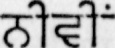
ਨੀਵੀਂ
